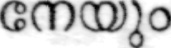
നേയും
